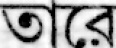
তারে
